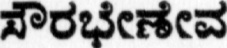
ಸೌರಭೇಣೇವ
